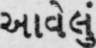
આવેલું
